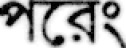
পরেং
